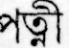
পত্নী
